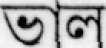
ভাল
